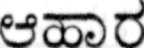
ಆಹಾರ
